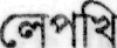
লেপখি
